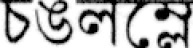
চঙলম্লে
